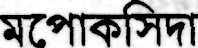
মপোকসিদা
